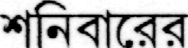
শনিবারের
